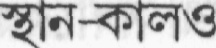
স্থান-কালও
